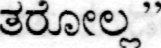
ತರೋಲ್ಲ"
